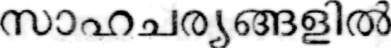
സാഹചര്യങ്ങളില്‍
